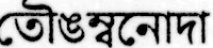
তৌঙম্বনোদা
